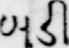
બડી
